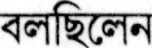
বলছিলেন
